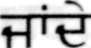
ਜਾਂਦੇ
